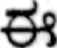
ಈ
